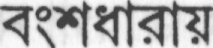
বংশধারায়
